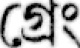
গ্রেং
